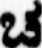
ಚ
